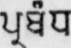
ਪ੍ਰਬੰਧ
